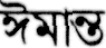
ঈমান্ত
